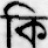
কি
